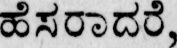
ಹೆಸರಾದರೆ,
